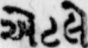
,એટલે
